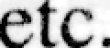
ect.
